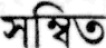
সম্বিত
